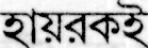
হায়রকই
